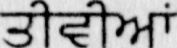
ਤੀਵੀਆਂ
